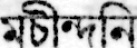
মচীন্দিনি
